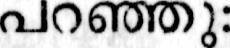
പറഞ്ഞു:
